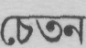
চেতন
